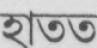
হাতত
